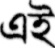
এই
